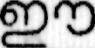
ഈ
